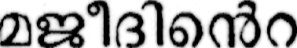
മജീദിന്റെ
